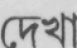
দেখা
